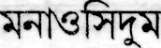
মনাওসিদুম
